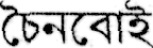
চৈনবোই
